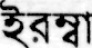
ইরম্বা
